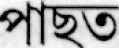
পাছত
